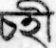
চহী
